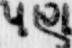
પણ
